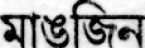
মাঙজিন
